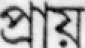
প্রায়
